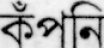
কঁপনি
